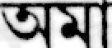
অমা
